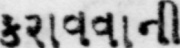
કરાવવાની
